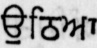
ਉਠਿਆ
